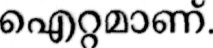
ഐറ്റമാണ്.
